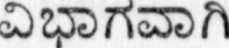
ವಿಭಾಗವಾಗಿ
